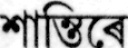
শান্তিৰে
